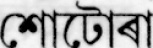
শোটোৰা
